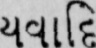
યવાદિ
